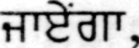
ਜਾਏਂਗਾ,
